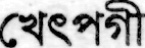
খেৎপগী
